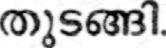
തുടങ്ങി.
